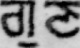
ਗੁਣ
